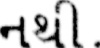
નથી.
